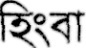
হিংবা
